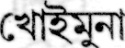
খোইমুনা
